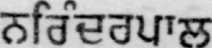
ਨਰਿੰਦਰਪਾਲ
